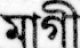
মাগী
